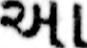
આ
